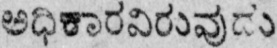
ಅಧಿಕಾರವಿರುವುದು
